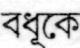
বধূকে
